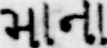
માના
